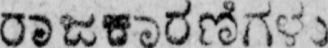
ರಾಜಕಾರಣಿಗಳು
